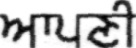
ਆਪਣੀ
